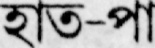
হাত-পা
